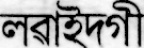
লৱাইদগী
